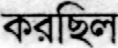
করছিল
